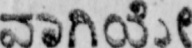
ವಾಗಿಯೇ
